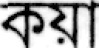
কয়া
